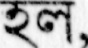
হল,
